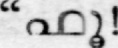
"ഫൂ!
